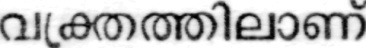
വക്ത്രത്തിലാണ്
